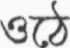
ওঠে
